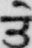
ਤੇ
